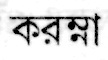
করম্না
